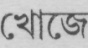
খোজে
